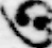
ও
